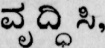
ವೃದ್ಧಿಸಿ,
